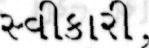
સ્વીકારી,
